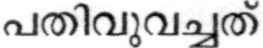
പതിച്ചുവച്ചത്
